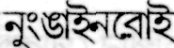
নুংঙাইনরোই
